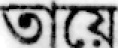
তায়ে
